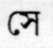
সে
